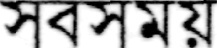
সবসময়
